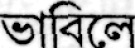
ভাবিলে
